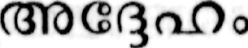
അദ്ദേഹം
